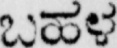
ಬಹಳ
